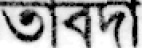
তাবদা
